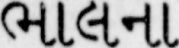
ભાલના
